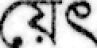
য়েৎ
